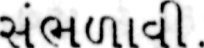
સંભળાવી.
